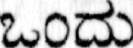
ಒಂದು
